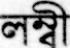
লম্বী
